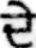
ਦੇ
